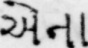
એના
